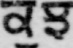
ਕੁਝ
